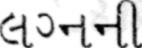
લગ્નની
